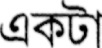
একটা
